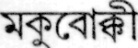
মকুবোক্কী
